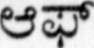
ಆಫ್
